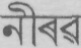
নীৰৱ
